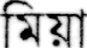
মিয়া
